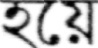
হয়ে
